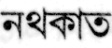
নথকাত
